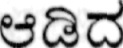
ಆಡಿದ
